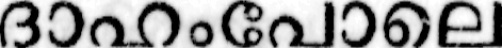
ദാഹംപോലെ
